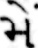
મેં
